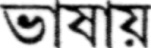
ভাষায়
